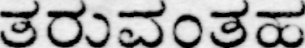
ತರುವಂತಹ
